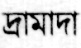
দ্রামাদা
